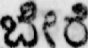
ಬೇರೆ
